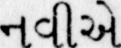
નવીએ
